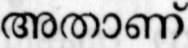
അതാണ്
